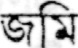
জমি
